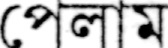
পেলাম
